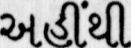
અહીંથી
